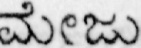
ಮೇಜು
